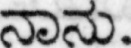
ನಾನು.
